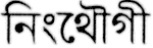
নিংথৌগী
